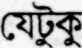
যেটুকু
